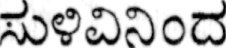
ಸುಳಿವಿನಿಂದ
